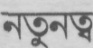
নতুনত্ব
